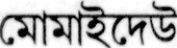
মোমাইদেউ
